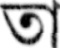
তা
